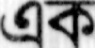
এক
